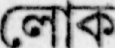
লোক
